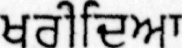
ਖਰੀਦਿਆ
